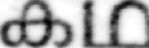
കഥ
